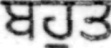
ਬਹੁਤ
